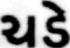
ચડે
